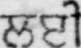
ਲਈ
